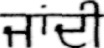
ਜਾਂਦੀ
